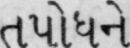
તપોધને
